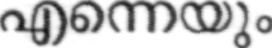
എന്നെയും
